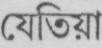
যেতিয়া
